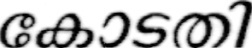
കോടതി
